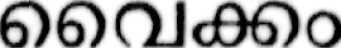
വൈക്കം
